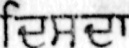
ਦਿਸਦਾ
